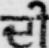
ਦੀ
